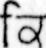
ਕਿ
